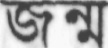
জন্ম
